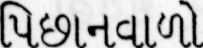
પિછાનવાળો
